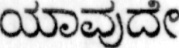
ಯಾವುದೇ
